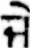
ਜੇ
